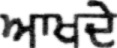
ਆਖਦੇ
